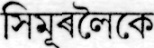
সিমূৰলৈকে
